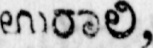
ಉರಾಲಿ,
